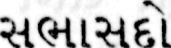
સભાસદો
